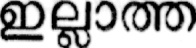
ഇല്ലാത്ത
